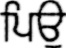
ਪਿਉ
